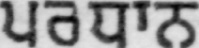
ਪਰਧਾਨ
